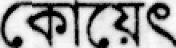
কোয়েৎ
